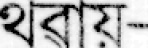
থৱায়-
